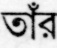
তাঁর
